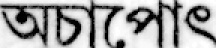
অচাপোৎ
